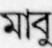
মাবু
